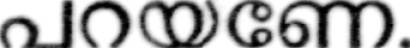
പറയണേ.
